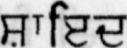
ਸ਼ਾਇਦ
